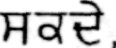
ਸਕਦੇ,
